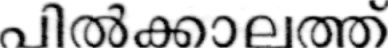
പില്‍ക്കാലത്ത്
